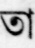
তা
